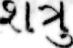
શત્રુ
